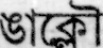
ঙাক্লৌ
